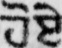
ਹੋਏ
